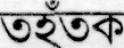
তহঁতক
